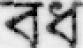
বধ
